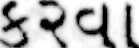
કરવા
